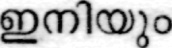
ഇനിയും
